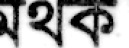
মথক
